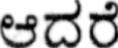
ಆದರೆ
